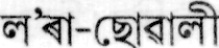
ল'ৰা-ছোৱালী
